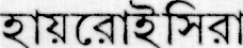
হায়রোইসিরা
